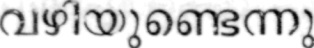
വഴിയുണ്ടെന്നു
